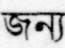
জন্য
